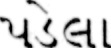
પડેલા
